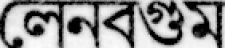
লেনবগুম
